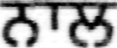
ਨਾਲ
